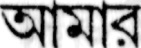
আমার
